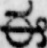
ಈ
